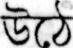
উঠে
